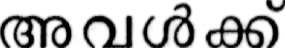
അവള്‍ക്ക്
